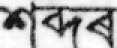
শব্দৰ
